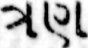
ત્રણ
